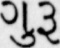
ગુરૂ
